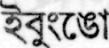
ইবুংঙো
